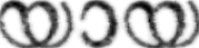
യായ
